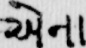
એના
